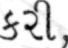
કરી,
